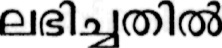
ലഭിച്ചതില്‍
